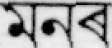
মনৰ
